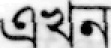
এখন
